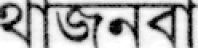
থাজনবা
